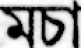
মচা
